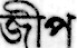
জীপ
